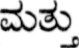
ಮತ್ತು
